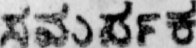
ಸಮರ್ಪಕ
